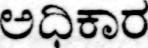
ಅಧಿಕಾರ
